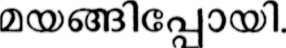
മയങ്ങിപ്പോയി.
